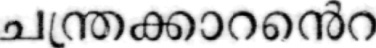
ചന്ത്രക്കാറന്റെ
